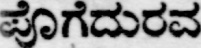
ಪೊಗೆದುರುವ
